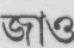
জাও
